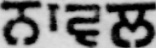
ਨਾਵਲ
